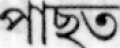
পাছত
